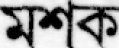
মশক
